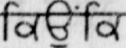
ਕਿਉਂਕਿ
